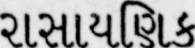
રાસાયણિક
